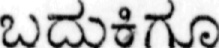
ಬದುಕಿಗೂ
